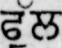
ਫੁੱਲ
